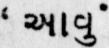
'આવું
